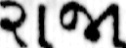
રાજા
